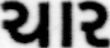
ચાર
